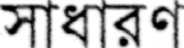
সাধারণ
